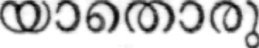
യാതൊരു
